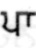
ਪਾ
